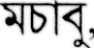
মচাবু,
